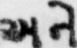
અને
